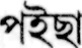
পইছা
